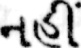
નહીં
